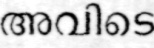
അവിടെ
